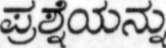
ಪ್ರಶ್ನೆಯನ್ನು
